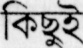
কিছুই
